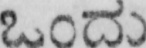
ಒಂದು
